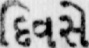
દિવસે
